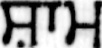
ਸ਼ਾਮ
